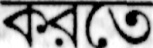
করতে
